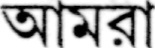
আমরা
